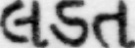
લડત
